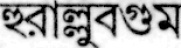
হুরাল্লুবগুম
